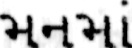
મનમાં
